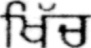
ਖਿੱਚ
